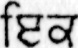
ਇਕ
